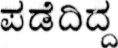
ಪಡೆದಿದ್ದ
